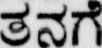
ತನಗೆ
